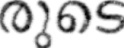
രുടെ
